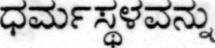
ಧರ್ಮಸ್ಥಳವನ್ನು
